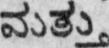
ಮತ್ತು
